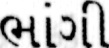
ભાંગી
